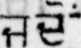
ਜਦੋਂ
